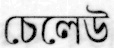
চেলেউ
